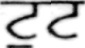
ਟੁਟ
